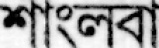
শাংলবা
